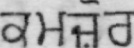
ਕਮਜ਼ੋਰ
